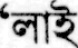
‘লাই
